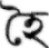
হৈ
